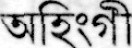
অহিংগী
